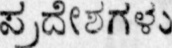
ಪ್ರದೇಶಗಳು
